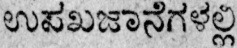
ಉಪಖಜಾನೆಗಳಲ್ಲಿ
